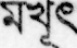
মখূৎ
